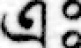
এঃ
